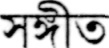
সঙ্গীত
